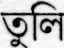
তুলি
